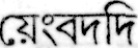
য়েংবদদি
